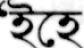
“ইহে
